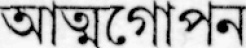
আত্মগোপন
